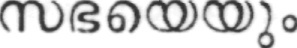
സഭയെയും
